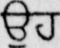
ਉਹ
